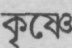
কৃষ্ণে
